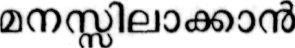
മനസ്സിലാക്കാന്‍
